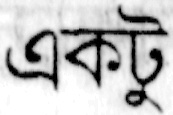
একটু
